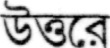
উত্তরে
